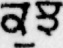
ਕੁਝ
